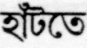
হাঁটতে
